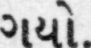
ગયો.
